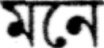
মনে
